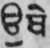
ਉਥੇ
